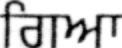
ਗਿਆ
